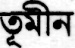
তূমীন
